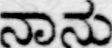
ನಾನು
